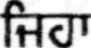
ਜਿਹਾ
